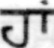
ਹਾਂ
